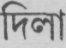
দিলা
